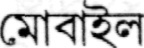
মোবাইল
